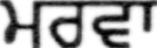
ਮਰਵਾ
